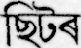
ছিটৰ
